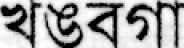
খঙবগা
